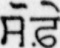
ਸੋਫ਼ੇ
